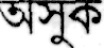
অসুক
